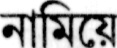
নামিয়ে
